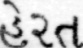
હેરત
